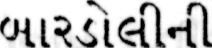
બારડોલીની
